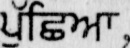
ਪੁੱਛਿਆ,
